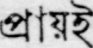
প্রায়ই
